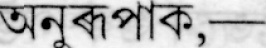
অনুৰূপাক,-
